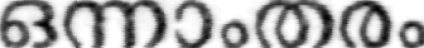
ഒന്നാംതരം
